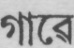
গাৱে
